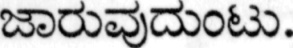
ಜಾರುವುದುಂಟು.
